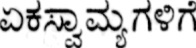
ಏಕಸ್ವಾಮ್ಯಗಳಿಗೆ
